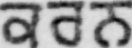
ਕਰਨ
